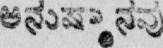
ಅನುಷ್ಟಾನವು
